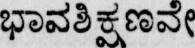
ಭಾವಶಿಕ್ಷಣವೇ
